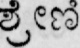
ಶ್ರೇಣಿ
